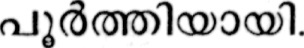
പൂര്‍ത്തിയായി.
